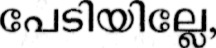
പേടിയില്ലേ,
